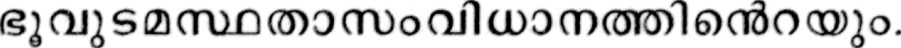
ഭൂവുടമസ്ഥതാസംവിധാനത്തിന്റെയും.
